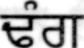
ਢੰਗ
